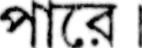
পারে।
